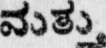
ಮತ್ತು
